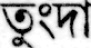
তুংদা
